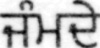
ਜੰਮਦੇ
